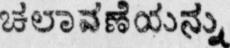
ಚಲಾವಣೆಯನ್ನು
